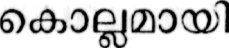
കൊല്ലമായി
